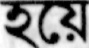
হয়ে
